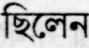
ছিলেন
